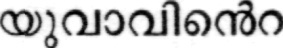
യുവാവിന്റെ
